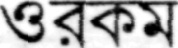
ওরকম
